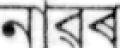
নাৱৰ
